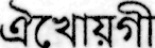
ঐখোয়গী
